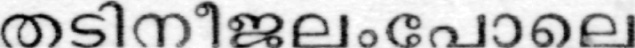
തടിനീജലംപോലെ
